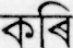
কৰি
